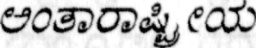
ಅಂತಾರಾಷ್ಟ್ರೀಯ
